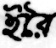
ইরৈ
